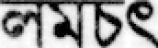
লমচৎ
